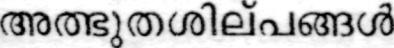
അത്ഭുതശില്പങ്ങള്‍
